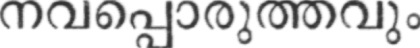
നവപ്പൊരുത്തവും
